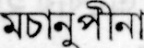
মচানুপীনা
